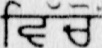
ਵਿੱਚੋਂ
